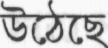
উঠেছে
